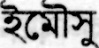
ইমৌসু
